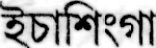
ইচাশিংগা
